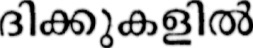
ദിക്കുകളില്‍
